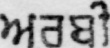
ਅਰਬੀ
